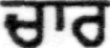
ਚਾਰ
